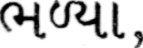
ભળ્યા,
